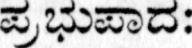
ಪ್ರಭುಪಾದ:
